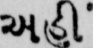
અહીં
